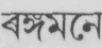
ৰঙ্গমনে
